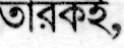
তারকই,
